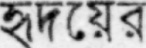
হৃদয়ের
